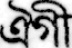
ঐগী
